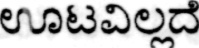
ಊಟವಿಲ್ಲದೆ
